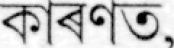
কাৰণত,
